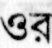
ওর
